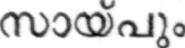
സായ്പും
